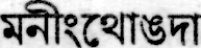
মনীংথোঙদা
